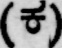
(ಕ)
